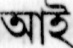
আই
